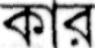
কার
